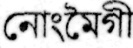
নোংমৈগী
